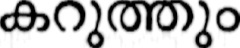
കറുത്തും
